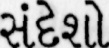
સંદેશો
